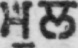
ਮੁਲ
